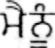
ਮੈਨੂੰ
